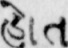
હોત
